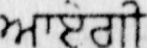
ਆਏਗੀ
